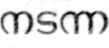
നടന്ന
